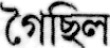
গৈছিল
